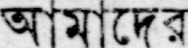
আমাদের
